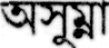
অসুম্না
